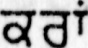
ਕਰਾਂ
